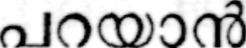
പറയാന്‍
